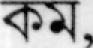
কম,
